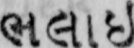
ભલાઈ
